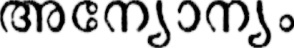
അന്യോന്യം
